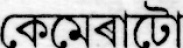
কেমেৰাটো
